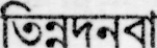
তিন্নদনবা
